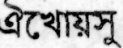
ঐখোয়সু
